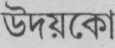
উদয়কো
